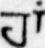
ਹਾਂ
